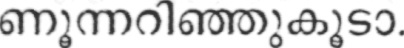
ണൂന്നറിഞ്ഞുകൂടാ.
